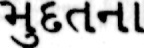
મુદતના
